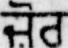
ਜ਼ੋਰ
